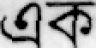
এক
